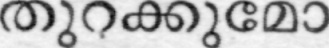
തുറക്കുമോ
